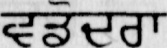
ਵਡੋਦਰਾ
